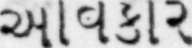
આવકાર
